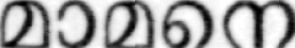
മാമനെ
